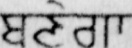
ਬਣੇਗਾ
